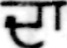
ਦਾ
